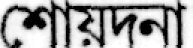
শোয়দনা
